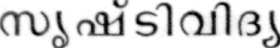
സൃഷ്ടിവിദ്യ
